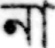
না
